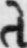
તે
